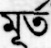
মূৰ্ত
